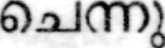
ചെന്നു
